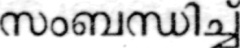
സംബന്ധിച്ച്
